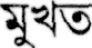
মুখত
